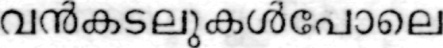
വന്‍കടലുകള്‍പോലെ
